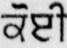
ਕੋਈ
